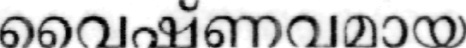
വൈഷ്ണവമായ
